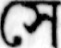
সে
